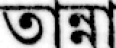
তান্না
